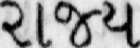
રાજ્ય
